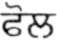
ਫੋਲ
